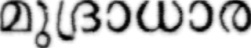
മുദ്രാധാര
